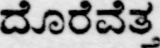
ದೊರೆವೆತ್ತ
